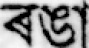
ৰঙা
